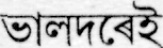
ভালদৰেই
